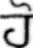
ਹੋ
